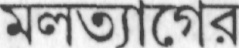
মলত্যাগের
